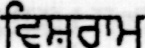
ਵਿਸ਼ਰਾਮ
